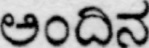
ಅಂದಿನ
